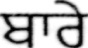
ਬਾਰੇ
